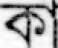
কা
